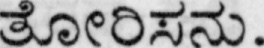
ತೋರಿಸನು.
